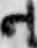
ન
